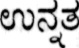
ಉನ್ನತ
